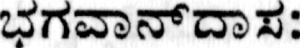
ಭಗವಾನ್‌ದಾಸ:
